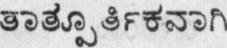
ತಾತ್ಪೂರ್ತಿಕವಾಗಿ
